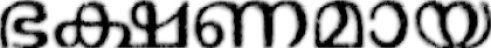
ഭക്ഷണമായ
